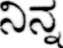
ನಿನ್ನ
